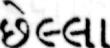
છેલ્લા
